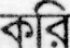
করি
